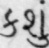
કશું
